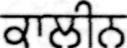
ਕਾਲੀਨ
